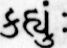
કહ્યું:
